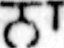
ਨਾ
